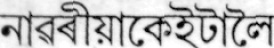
নাৱৰীয়াকেইটালৈ
